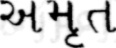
અમૃત
